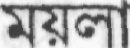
ময়লা
